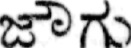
ಜೌಗು
